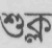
শুক্ল
